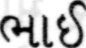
ભાઈ
